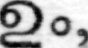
ഉം,
